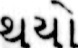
થયો
